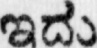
ಇದು
